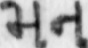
મન
